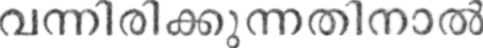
വന്നിരിക്കുന്നതിനാല്‍
